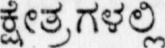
ಕ್ಷೇತ್ರಗಳಲ್ಲಿ
